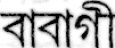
বাবাগী
